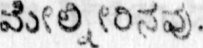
ಮೇಲ್ನೀರಿನವು.
